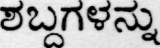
ಶಬ್ದಗಳನ್ನು
